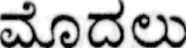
ಮೊದಲು
